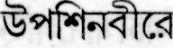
উপশিনবীরে
